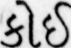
કોઈ
